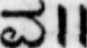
ವ||
